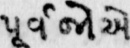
પૂર્વજોએ
